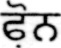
ਫ਼ੋਨ
